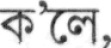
ক'লে,
